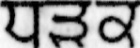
ਧੜਕ
